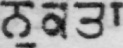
ਨੁਕਤਾ
